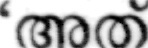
'അത്
